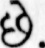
છે.
